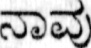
ನಾವು
